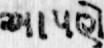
આપણે
